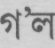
গ'ল
